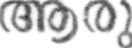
ആരു
